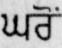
ਘਰੋਂ
